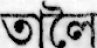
তালৈ
